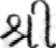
શ્રી
